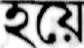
হয়ে
